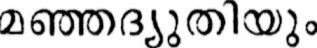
മഞ്ഞദ്യുതിയും
